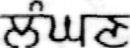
ਲੰਘਣ
